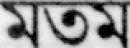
মতম
